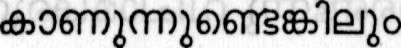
കാണുന്നുണ്ടെങ്കിലും
